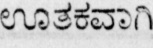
ಊತಕವಾಗಿ
